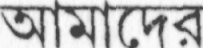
আমাদের
